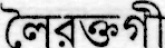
লৈরক্তগী
